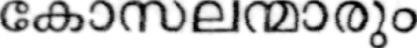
കോസലന്മാരും
